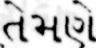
તેમણે
